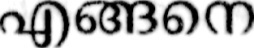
എങ്ങനെ
